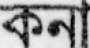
কনা
